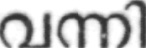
വന്നി
